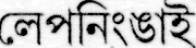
লেপনিংঙাই
